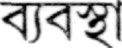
ব্যবস্থা
